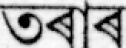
তৰাৰ
